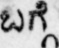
ಬಗ್ಗೆ
